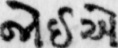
જોઈએ
